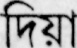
দিয়া
